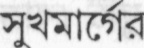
সুখমার্গের
